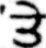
'ਤੇ
